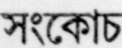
সংকোচ
